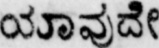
ಯಾವುದೇ
